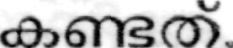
കണ്ടത്.
